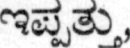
ಇಪ್ಪತ್ತು,
